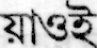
য়াওই
